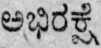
ಅಭಿರಕ್ಷೆ
